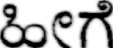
ಹೀಗೆ
